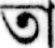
তা
